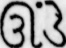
ઊંડે
